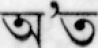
অ'ত
